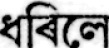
ধৰিলে
